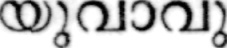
യുവാവു
